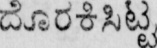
ದೊರಕಿಸಿಟ್ಟ
